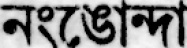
নংঙোন্দা
